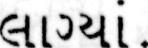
લાગ્યાં.
